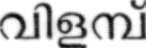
വിളമ്പ്
